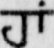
ਹਾਂ
